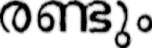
രണ്ടും
